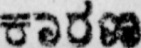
ಕಾರಣ
